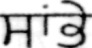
ਸਾਂਭੇ
